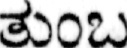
ತುಂಬ
